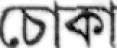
চোকা
